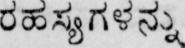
ರಹಸ್ಯಗಳನ್ನು
